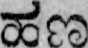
ಹಣ
